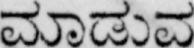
ಮಾಡುವ
